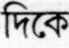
দিকে
